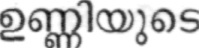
ഉണ്ണിയുടെ
